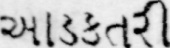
આડકતરી
